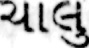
ચાલુ
